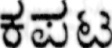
ಕಪಟ
